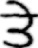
ਤੇ
